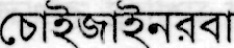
চোইজাইনরবা
